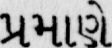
પ્રમાણે
